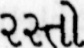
રસ્તો
